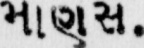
માણસ.
